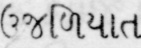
ઉજળિયાત
